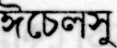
ঈচেলসু
